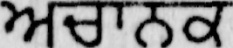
ਅਚਾਨਕ
